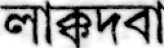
লাক্কদবা
